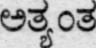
ಅತ್ಯಂತ
